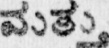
ಮತ್ತು
